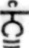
ਨੂੰ
